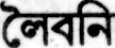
লৈবনি
